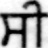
ਸੀ
